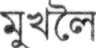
মুখলৈ
